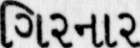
ગિરનાર
